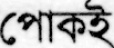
পোকই
